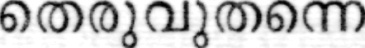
തെരുവുതന്നെ
